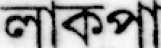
লাকপা
